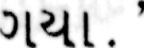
ગયા.
